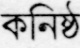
কনিষ্ঠ
